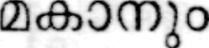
മകാനും
